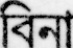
বিনা
